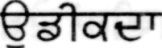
ਉਡੀਕਦਾ
